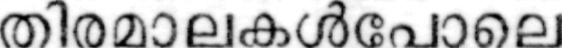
തിരമാലകള്‍പോലെ
